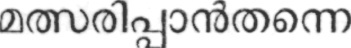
മത്സരിപ്പാന്‍തന്നെ
